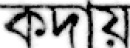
কদায়
